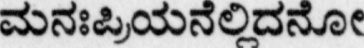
ಮನಃಪ್ರಿಯನೆಲ್ಲಿದನೋ
